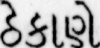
ઠેકાણે
